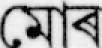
মোৰ
